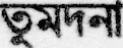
তুমদনা
